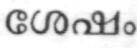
ശേഷം
